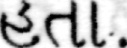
હતા.
